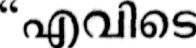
“എവിടെ
